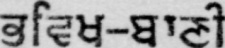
ਭਵਿਖ-ਬਾਣੀ
